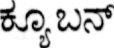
ಕ್ಯೂಬನ್
